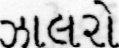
ઝાલરો
